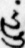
હું
